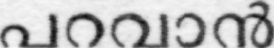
പറവാന്‍
